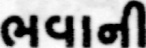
ભવાની
